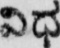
ವಿಧ
